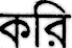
করি
